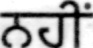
ਨਹੀਂ
